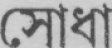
সোধা
